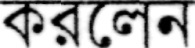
করলেন
